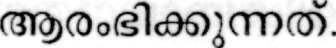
ആരംഭിക്കുന്നത്.
